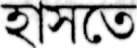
হাসতে
